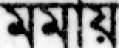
মমায়
